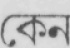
কেন
